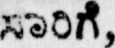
ಸಾರಿಗೆ,
